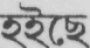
হইছে
